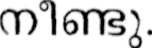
നീണ്ടു.
